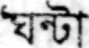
ঘন্টা
